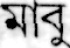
মাবু
